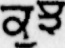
ਕੁਝ
